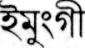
ইমুংগী
